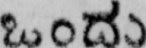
ಒಂದು
